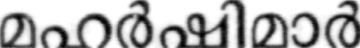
മഹര്‍ഷിമാര്‍
